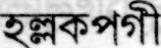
হল্লকপগী
